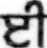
ਈ
